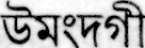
উমংদগী
